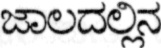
ಜಾಲದಲ್ಲಿನ
